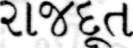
રાજદૂત
